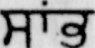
ਸਾਂਭ
